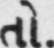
તો.
